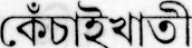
কেঁচাইখাতী
